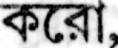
করো,
